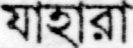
যাহারা
